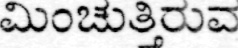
ಮಿಂಚುತ್ತಿರುವ
